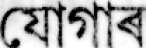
যোগাৰ
